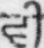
ਵੀ
